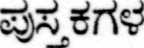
ಪುಸ್ತಕಗಳ
